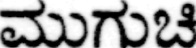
ಮುಗುಚಿ
